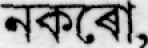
নকৰো,
